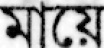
মায়ে
